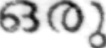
ഒരു
